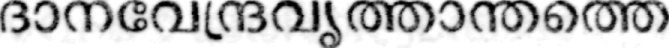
ദാനവേന്ദ്രവൃത്താന്തത്തെ
